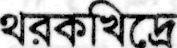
থরকখিদ্রে
